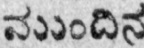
ಮುಂದಿನ
